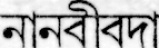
নানবীবদা
